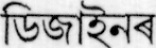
ডিজাইনৰ
